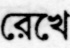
রেখে
